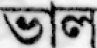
ভাল
